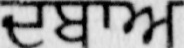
ਦਬਾਅ
